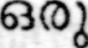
ഒരു
